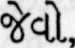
જેવો,
